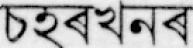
চহৰখনৰ
